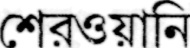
শেরওয়ানি
